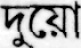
দুয়ো
